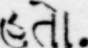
હતો.
